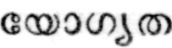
യോഗ്യത
